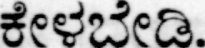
ಕೇಳಬೇಡಿ.
